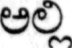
ಅಲ್ಲಿ
